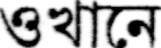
ওখানে
